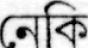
নেকি
